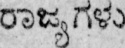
ರಾಜ್ಯಗಳು
